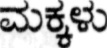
ಮಕ್ಕಳು
